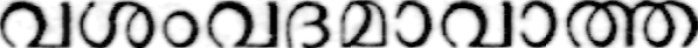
വശംവദമാവാത്ത
